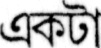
একটা
